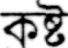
কষ্ট
